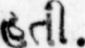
હતી.
